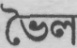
ভৈল
